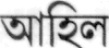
আহিল
